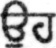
ਉਹ
